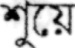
শুয়ে
